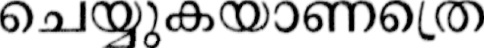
ചെയ്യുകയാണത്രെ
